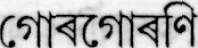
গোৰগোৰণি
